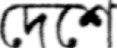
দেশে
